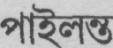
পাইলন্ত
